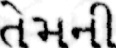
તેમની
